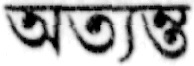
অত্যন্ত
